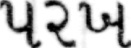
પરખ
